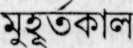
মুহূর্তকাল
